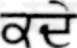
ਕਦੇ
